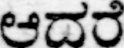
ಆದರೆ
